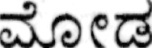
ಮೋಡ
